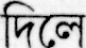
দিলে
